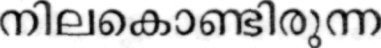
നിലകൊണ്ടിരുന്ന
